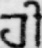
ਹੀ
